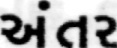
અંતર
